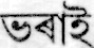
ভৰাই
